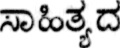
ಸಾಹಿತ್ಯದ
